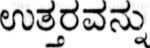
ಉತ್ತರವನ್ನು
